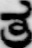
ತ
